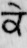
ਕੇ
